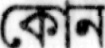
কোন
